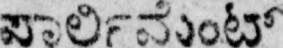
ಪಾರ್ಲಿಮೆಂಟ್
